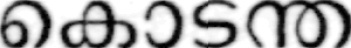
കൊടന്ത
